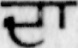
ਦਾ
